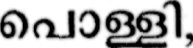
പൊള്ളി,
